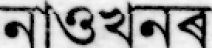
নাওখনৰ
